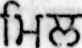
ਮਿਲ
